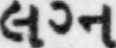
લગ્ન
